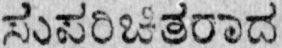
ಸುಪರಿಚಿತರಾದ
